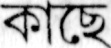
কাছে
